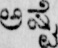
ಅಷ್ಟೆ
